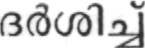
ദര്‍ശിച്ച്
